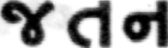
જતન
